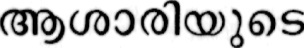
ആശാരിയുടെ
